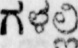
ಗಳಲ್ಲಿ
